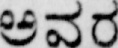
ಅವರ
